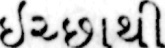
ઇચ્છાથી
